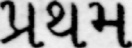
પ્રથમ
